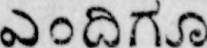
ಎಂದಿಗೂ
